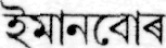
ইমানবোৰ
